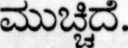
ಮುಚ್ಚಿದೆ.
